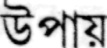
উপায়
